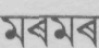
মৰমৰ
